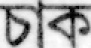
চাক
